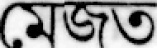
মেজত
